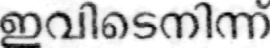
ഇവിടെനിന്ന്
